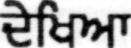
ਦੇਖਿਆ
